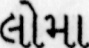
લોમા
